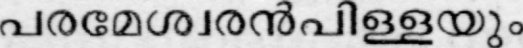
പരമേശ്വരന്‍പിള്ളയും
